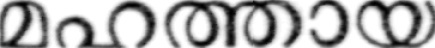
മഹത്തായ
